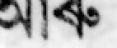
আৰু
